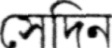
সেদিন
